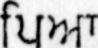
ਪਿਆ
